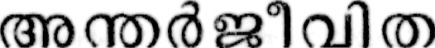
അന്തര്‍ജീവിത
